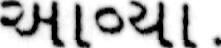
આવ્યા.
